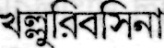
খল্লুরিবসিনা
